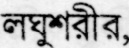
লঘুশরীর,
